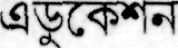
এডুকেশন
